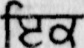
ਇਕ
